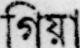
গিয়া
